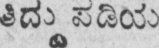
ತಿದ್ದುಪಡಿಯ
